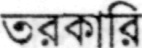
তরকারি
